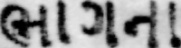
ભાગના
